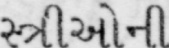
સ્ત્રીઓની
